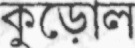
কুড়োল
